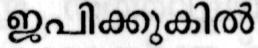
ജപിക്കുകില്‍
